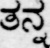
ತನ್ನ
